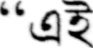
“এই
